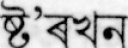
ষ্ট'ৰখন
